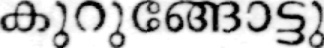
കുറുങ്ങോട്ടു
